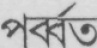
পৰ্ব্বত
